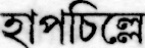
হাপচিল্লে
